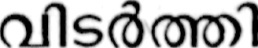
വിടര്‍ത്തി
